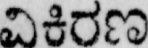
ವಿಕಿರಣ
